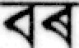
বৰ
